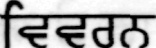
ਵਿਵਰਨ
